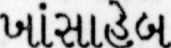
ખાંસાહેબ
